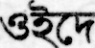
ওইদে
